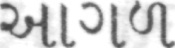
આગળ
